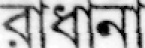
রাধানা
